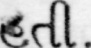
હતી.
